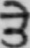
ਤੇ
